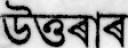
উত্তৰাৰ
